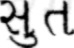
સુત
